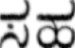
ಸಹ
